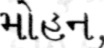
મોહન,
